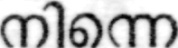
നിന്നെ
